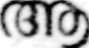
ആ
